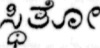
ಸ್ಥಿತೋ
